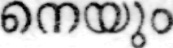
നെയും
